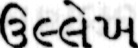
ઉલ્લેખ
